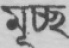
মূচ্ছ
